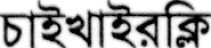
চাইখাইরক্লি
